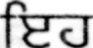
ਇਹ
